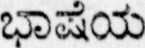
ಭಾಷೆಯ
